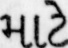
માટે
